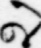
જે
